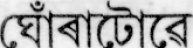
ঘোঁৰাটোৱে
